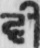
ਵੀ
